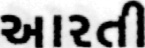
આરતી
